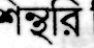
শিন্থরি
